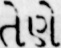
તેણે
